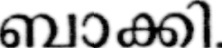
ബാക്കി.
